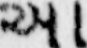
આ
